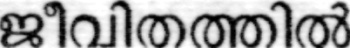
ജീവിതത്തില്‍
